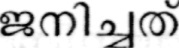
ജനിച്ചത്
